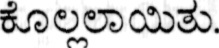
ಕೊಲ್ಲಲಾಯಿತು.
